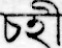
চহী
